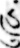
હું
